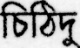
চিঠিদু
